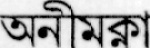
অনীমক্না
